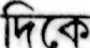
দিকে
